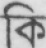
কি
